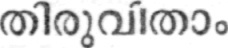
തിരുവിതാം
